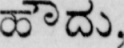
ಹೌದು,
